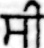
ਸੀ
